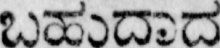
ಬಹುದಾದ
